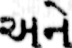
અને
